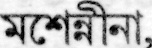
মশেন্নীনা,
